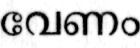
വേണം
